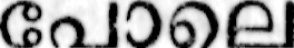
പോലെ
